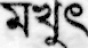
মখুৎ
